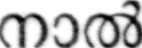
നാല്‍
